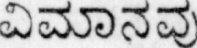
ವಿಮಾನವು
